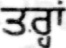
ਤਰ੍ਹਾਂ
